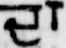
ਦਾ
